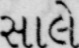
સાલે
